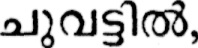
ചുവട്ടില്‍,
